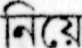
নিয়ে
